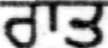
ਰਾਤ
